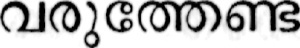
വരുത്തേണ്ട
